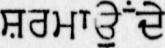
ਸ਼ਰਮਾਉਂਦੇ
